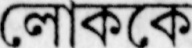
লোককে
